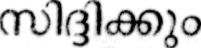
സിദ്ദിക്കും
